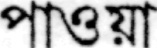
পাওয়া
